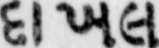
દાખલ
